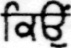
ਕਿਉਂ
